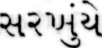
સરખુંયે
